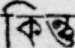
কিন্তু
